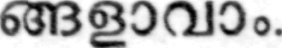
ങ്ങളാവാം.
